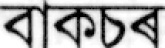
বাকচৰ
